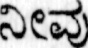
ನೀವು
